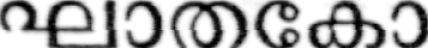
ഘാതകോ
